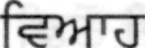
ਵਿਆਹ
